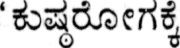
'ಕುಷ್ಠರೋಗಕ್ಕೆ
